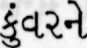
કુંવરને
